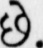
છે.
